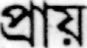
প্রায়
